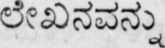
ಲೇಖನವನ್ನು
